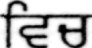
ਵਿਚ
